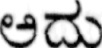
ಅದು
